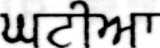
ਘਟੀਆ
